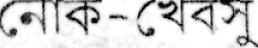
নোক-খেবসু
